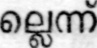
ല്ലെന്ന്
